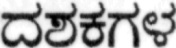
ದಶಕಗಳ
